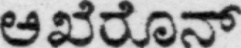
ಅಖೆರೊನ್
